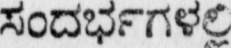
ಸಂದರ್ಭಗಳಲ್ಲಿ
